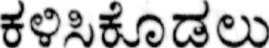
ಕಳಿಸಿಕೊಡಲು
